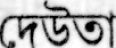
দেউতা
